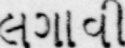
લગાવી
